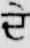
ਦੇ
